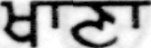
ਖਾਣਾ
